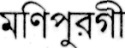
মণিপুরগী
